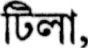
টিলা,
